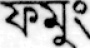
ফমুং
